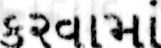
કરવામાં
